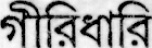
গীরিধারি
